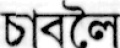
চাবলৈ
